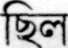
ছিল
